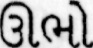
ઊભો
